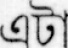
এটা
